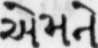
એમને
